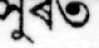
সুৰত
